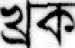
খ্রক
